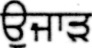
ਉਜਾੜ
